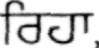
ਰਿਹਾ,
